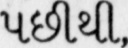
પછીથી,
